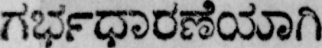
ಗರ್ಭಧಾರಣೆಯಾಗಿ
